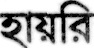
হায়রি
